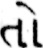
તો
